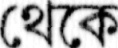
থেকে
